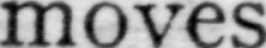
moves
